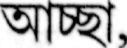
আচ্ছা,
